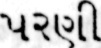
પરણી
